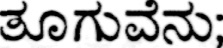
ತೂಗುವೆನು;
